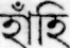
হাঁহি
